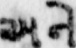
અને
